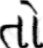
તો
